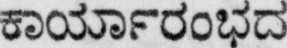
ಕಾರ್ಯಾರಂಭದ
